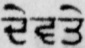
ਦੇਵਤੇ
